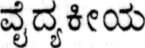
ವೈದ್ಯಕೀಯ
